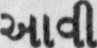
આવી
